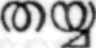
തയ്യ
